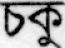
চকু
